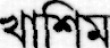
খাশিম
